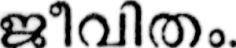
ജീവിതം.
